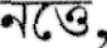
নত্তে,
